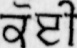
ਕੋਈ
